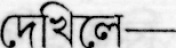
দেখিলে-
